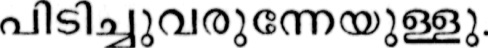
പിടിച്ചുവരുന്നേയുള്ളു.
